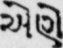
એણે
